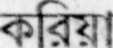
করিয়া
